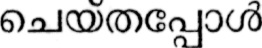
ചെയ്തപ്പോള്‍
